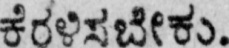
ಕೆರಳಿಸಬೇಕು.
